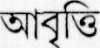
আবৃত্তি
